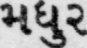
મધુર
